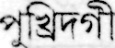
পুখ্রিদগী
